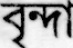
বৃন্দা
